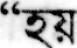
"হয়
